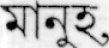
মানুহ,
